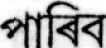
পাৰিব
